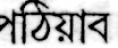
পঠিয়াব
